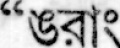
“ঙরাং
